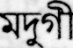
মদুগী
